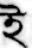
ই
